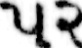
પર
